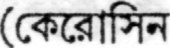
(কেরোসিন
